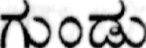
ಗುಂಡು
